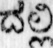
ದಲ್ಲಿ
